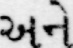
અને
